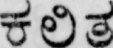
ಕಲಿತ
